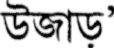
উজাড়'
